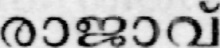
രാജാവ്
